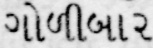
ગોળીબાર
